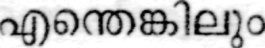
എന്തെങ്കിലും
